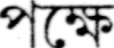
পক্ষে
